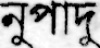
নুপাদু
